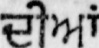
ਦੀਆਂ
